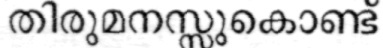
തിരുമനസ്സുകൊണ്ട്
